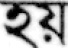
হয়
